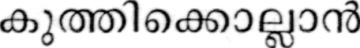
കുത്തിക്കൊല്ലാന്‍
